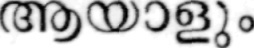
ആയാളും
